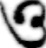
ও
